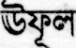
ঊফুল
